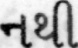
નથી
